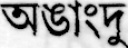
অঙাংদু
